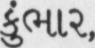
કુંભાર,
